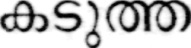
കടുത്ത
